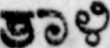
ತಾಳಿ
